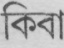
কিবা
